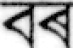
বৰ
